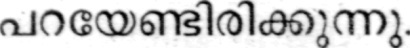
പറയേണ്ടിരിക്കുന്നു.
